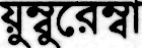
য়ুম্বুরেম্বা
